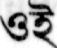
ওই
